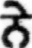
ਨੇ
